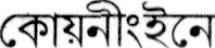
কোয়নীংইনে
